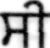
ਸੀ
